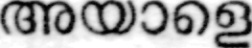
അയാളെ
